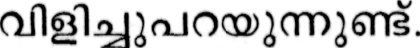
വിളിച്ചുപറയുന്നുണ്ട്.
